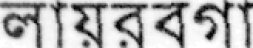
লায়রবগা
